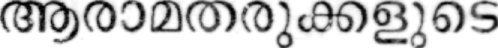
ആരാമതരുക്കളുടെ
